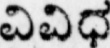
ವಿವಿಧ
